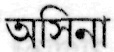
অসিনা
